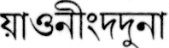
য়াওনীংদদুনা
